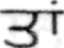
ਤਾਂ
